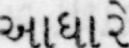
આધારે
